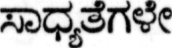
ಸಾಧ್ಯತೆಗಳೇ
